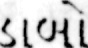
ડાબો
